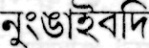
নুংঙাইবদি
